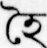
হৈ
